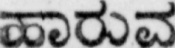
ಹಾರುವ
